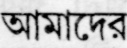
আমাদের
